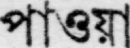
পাওয়া
